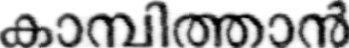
കാമ്പിത്താന്‍
